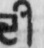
ਦੀ
